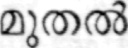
മുതല്‍
